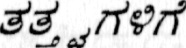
ತತ್ತ್ವಗಳಿಗೆ
